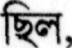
ছিল,
